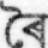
ৰৈ
